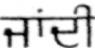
ਜਾਂਦੀ
